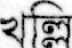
খল্লি
